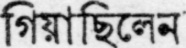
গিয়াছিলেন
